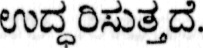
ಉದ್ಧರಿಸುತ್ತದೆ.
